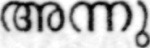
അന്നു
